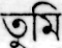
তুমি
